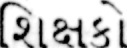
શિક્ષકો
